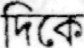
দিকে
